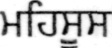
ਮਹਿਸੂਸ
